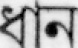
ধান
